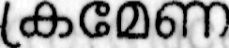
ക്രമേണ
